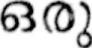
ഒരു
